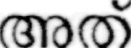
അത്
